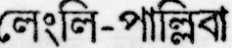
লেংলি-পাল্লিবা
